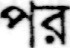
পর
